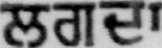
ਲਗਦਾ
